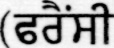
(ਫਰੈਂਸੀ
